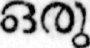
ഒരു
